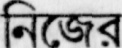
নিজের
